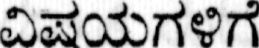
ವಿಷಯಗಳಿಗೆ
